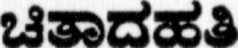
ಚಿತಾದಹತಿ
